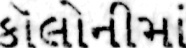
કૉલોનીમાં
